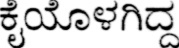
ಕೈಯೊಳಗಿದ್ದ
